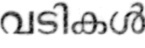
വടികള്‍
